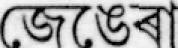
জেঙেৰা
